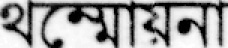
থম্মোয়না
